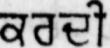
ਕਰਦੀ
